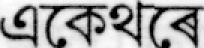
একেথৰে
